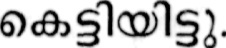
കെട്ടിയിട്ടു.
